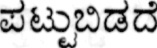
ಪಟ್ಟುಬಿಡದೆ
